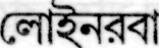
লোইনরবা
